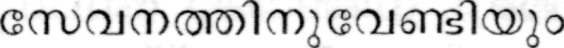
സേവനത്തിനുവേണ്ടിയും
